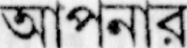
আপনার
